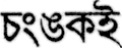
চংঙকই
